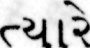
ત્યારે
